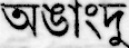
অঙাংদু
